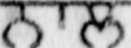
ਨਾਲ
